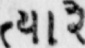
ત્યારે
